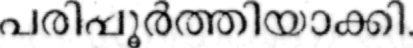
പരിപൂര്‍ത്തിയാക്കി.
